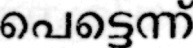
പെട്ടെന്ന്
